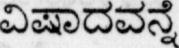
ವಿಷಾದವನ್ನೆ
